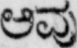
ಅವು
